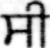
ਸੀ
